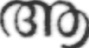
ആ
